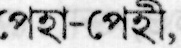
পেহা-পেহী,
